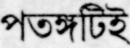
পতঙ্গটিই
